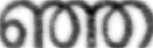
ഞ്ഞ
